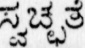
ಸ್ವಚ್ಛತೆ
